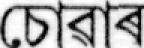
চোৱাৰ
